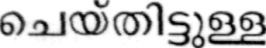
ചെയ്തിട്ടുള്ള
